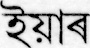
ইয়াৰ
